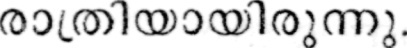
രാത്രിയായിരുന്നു.
